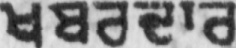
ਖਬਰਦਾਰ
